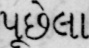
પૂછેલા
